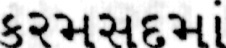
કરમસદમાં
